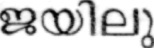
ജയിലു
